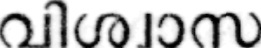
വിശ്വാസ
